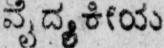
ವೈದ್ಯಕೀಯ
